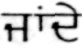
ਜਾਂਦੇ
